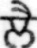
ਲੈ
